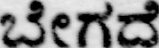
ಬೇಗದೆ
